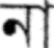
না
